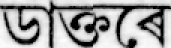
ডাক্তৰে
